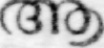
ആ
